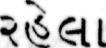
રહેલા
